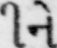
ીને
